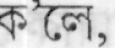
ক'লে,
